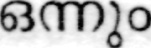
ഒന്നും
